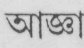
আজ্ঞা
